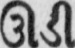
ઊડી
